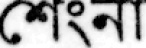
শেংনা
